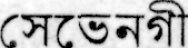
সেভেনগী
